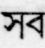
সব
